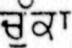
ਚੁੱਕਾ
